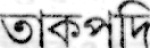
তাকপদি
